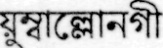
য়ুম্বাল্লোনগী
